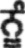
ਨੂੰ
